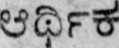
ಆರ್ಥಿಕ
